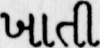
ખાતી
